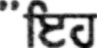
''ਇਹ
